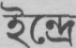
ইন্দ্ৰে
